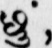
છું,
